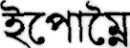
ইপোম্নৈ
